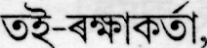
তই-ৰক্ষাকর্তা,
